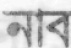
নাব
